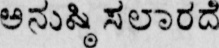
ಅನುಷ್ಠಿಸಲಾರದೆ
